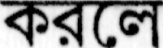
করলে
